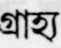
গ্রাহ্য
